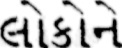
લોકોને
